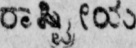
ರಾಷ್ಟ್ರೀಯ
